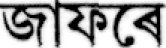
জাফৰে
